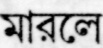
মারলে
